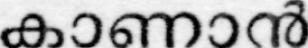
കാണാന്‍
